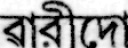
ৱারীদো
